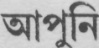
আপুনি
